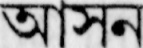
আসন
